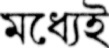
মধ্যেই
